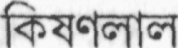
কিষণলাল
